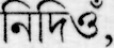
নিদিওঁ,
